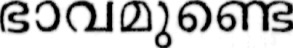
ഭാവമുണ്ടെ
